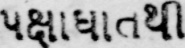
પક્ષાઘાતથી
